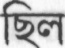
ছিল
